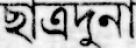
ছাত্রদুনা
